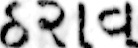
ઠરાવ
